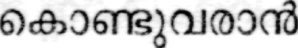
കൊണ്ടുവരാന്‍
